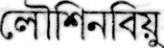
লৌশিনবিয়ু
